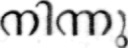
നിന്നു
